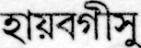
হায়বগীসু
